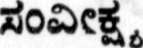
ಸಂವೀಕ್ಷ್ಯ
